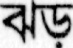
ঝড়
